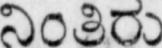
ನಿಂತಿರು
